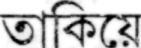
তাকিয়ে
